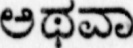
ಅಥವಾ
